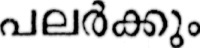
പലര്‍ക്കും
